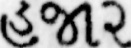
હજાર
